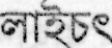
লাইচৎ
